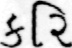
કરિ
